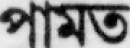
পামত
